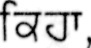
ਕਿਹਾ,
